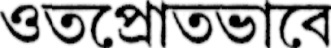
ওতপ্রোতভাবে
